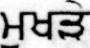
ਮੁਖੜੇ
